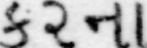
કરના
